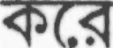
করে
